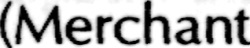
(Merchant
